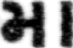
મા
